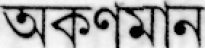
অকণমান
